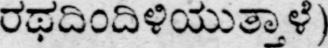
ರಥದಿಂದಿಳಿಯುತ್ತಾಳೆ)
